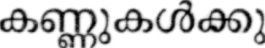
കണ്ണുകള്‍ക്കു
